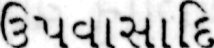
ઉપવાસાદિ
